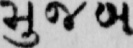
મુજબ
